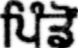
ਪਿੰਡੋਂ
